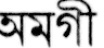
অমগী
